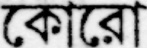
কোরো
